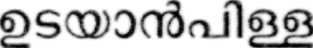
ഉടയാന്‍പിള്ള
